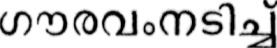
ഗൌരവംനടിച്ച്
